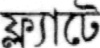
ফ্ল্যাটে
